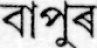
বাপুৰ
